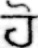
ਹੋ
